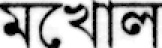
মখোল
